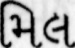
મિલ
